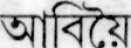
আবিয়ৈ
